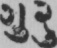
ગુરુ
